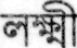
লক্ষ্মী
